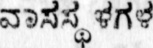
ವಾಸಸ್ಥಳಗಳ
